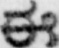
ಈ
